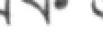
এক
